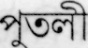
পুতলী
